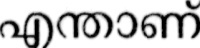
എന്താണ്
